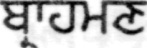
ਬ੍ਰਾਹਮਣ
